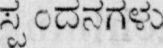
ಸ್ಪಂದನಗಳು
